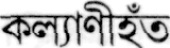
কল্যাণীহঁত
